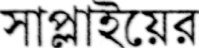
সাপ্লাইয়ের
